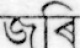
জৰি
